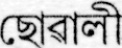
ছোৱালী
